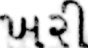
ખરી
